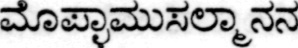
ಮೊಪ್ಳಾಮುಸಲ್ಮಾನನ
